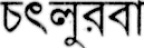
চৎলুরবা
